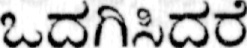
ಒದಗಿಸಿದರೆ
